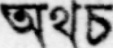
অথচ
